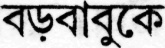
বড়বাবুকে
